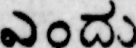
ಎಂದು
